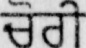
ਚੋਰੀ
